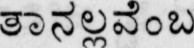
ತಾನಲ್ಲವೆಂಬ
